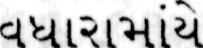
વધારામાંયે
